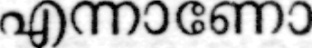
എന്നാണോ
